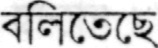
বলিতেছে
